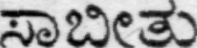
ಸಾಬೀತು
